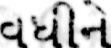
વધીને
